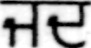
ਜਦ
